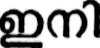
ഇനി
